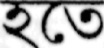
হতে
